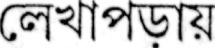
লেখাপড়ায়
